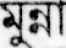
মুন্না
